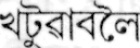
খটুৱাবলৈ
